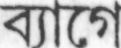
ব্যাগে
